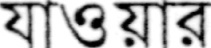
যাওয়ার
